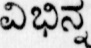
ವಿಭಿನ್ನ
